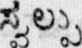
ಸ್ವಲ್ಪು
